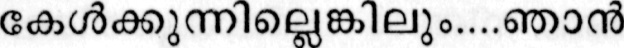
കേള്‍ക്കുന്നില്ലെങ്കിലും....ഞാന്‍
